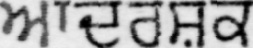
ਆਦਰਸ਼ਕ
